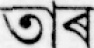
তাৰ
